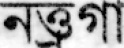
নত্ত্রগা
